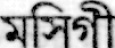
মসিগী
